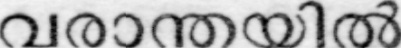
വരാന്തയില്‍
